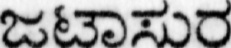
ಜಟಾಸುರ
